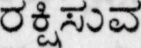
ರಕ್ಷಿಸುವ
